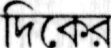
দিকের
